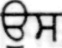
ਉਸ
